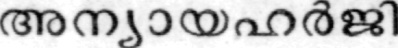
അന്യായഹര്‍ജി
